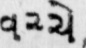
વચ્ચે,
